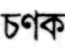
চণক
